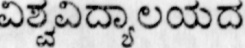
ವಿಶ್ವವಿದ್ಯಾಲಯದ
